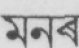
মনৰ
